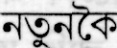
নতুনকৈ
